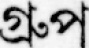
গ্ৰুপ
